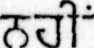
ਨਹੀਂ
